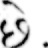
છે.
